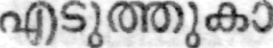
എടുത്തുകാ
